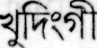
খুদিংগী
